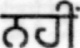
ਨਹੀਂ
